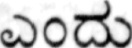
ಎಂದು
